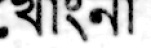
খোংনা
